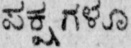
ಪಕ್ಷಗಳೂ
